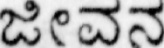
ಜೀವನ
